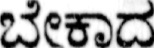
ಬೇಕಾದ
